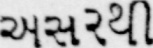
અસરથી
